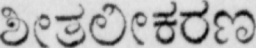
ಶೀತಲೀಕರಣ
